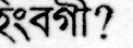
হিংবগী?
